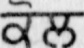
ਕੋਲ
